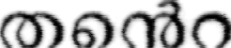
തന്റെ
